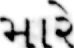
મારે
